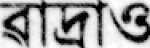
ৱাদ্রাও
